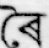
ৰৈ
